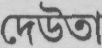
দেউতা
